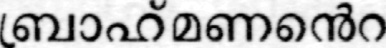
ബ്രാഹ്മണന്റെ
